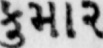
કુમાર
